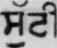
ਸੁੱਟੀ
